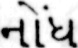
નોંધ
